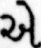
એ
